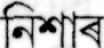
নিশাৰ
